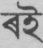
ৰই
